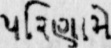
પરિણામે
